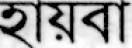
হায়বা
